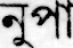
নুপা
